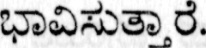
ಭಾವಿಸುತ್ತಾರೆ.
